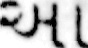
આ
